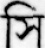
সি
